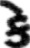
કે
